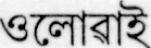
ওলোৱাই
